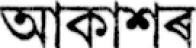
আকাশৰ
